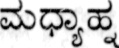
ಮಧ್ಯಾಹ್ನ
